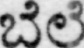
ಬೆಲೆ
